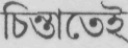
চিন্তাতেই
